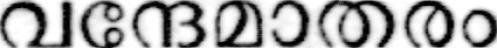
വന്ദേമാതരം
